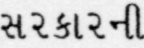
સરકારની
